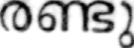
രണ്ടു
